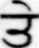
ਤੇ
